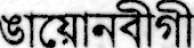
ঙায়োনবীগী
